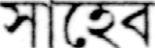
সাহেব
